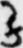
કે
